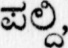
ಪಲ್ದಿ,
